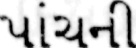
પાંચની
